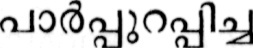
പാര്‍പ്പുറപ്പിച്ച
